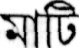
মাটি
